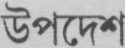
উপদেশ
